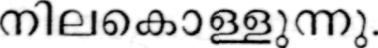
നിലകൊള്ളുന്നു.
